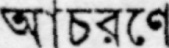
আচরণে
